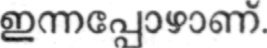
ഇന്നപ്പോഴാണ്.
